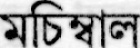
মচিম্বাল
